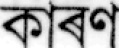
কাৰণ
